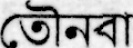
তৌনবা
